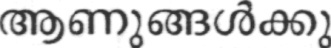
ആണുങ്ങള്‍ക്കു
